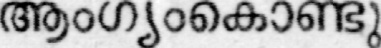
ആംഗ്യംകൊണ്ടു
